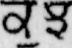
ਕੁਝ
